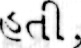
હતી,
